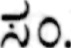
ಸಂ.
